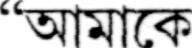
“আমাকে
